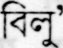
বিলু’
